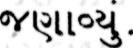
જણાવ્યું.
